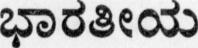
ಭಾರತೀಯ
